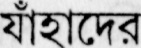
যাঁহাদের
